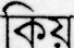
কিয়
